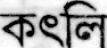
কৎলি
